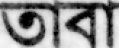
তাবা
